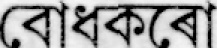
বোধকৰো
